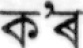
ক'ৰ
